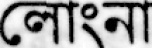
লোংনা
